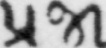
પ્રજા
